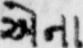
એના
